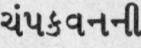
ચંપકવનની
